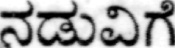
ನಡುವಿಗೆ
